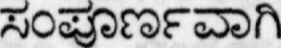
ಸಂಪೂರ್ಣವಾಗಿ
